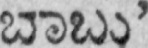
ಬಾಬು’
